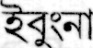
ইবুংনা
